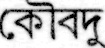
কৌবদু
